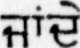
ਜਾਂਦੇ
